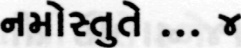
નમોસ્તુતે
